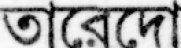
তারেদো
